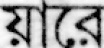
য়ারে
